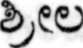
ಶ್ರೀಲ
